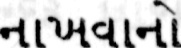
નાખવાનો
